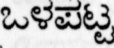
ಒಳಪಟ್ಟ
